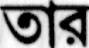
তার
